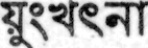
য়ুংখৎনা
